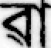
ৱা
